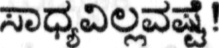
ಸಾಧ್ಯವಿಲ್ಲವಷ್ಟೆ!
